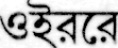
ওইররে
